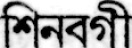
শিনবগী
